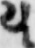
ય
